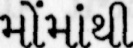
મોંમાંથી
